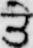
ਤੇ
